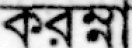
করম্না
